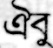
ঐবু
